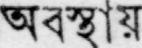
অবস্থায়
